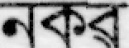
নকৱ
